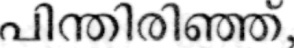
പിന്തിരിഞ്ഞ്,
